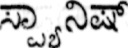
ಸ್ಪ್ಯಾನಿಷ್
